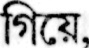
গিয়ে,
